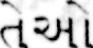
તેઓ
